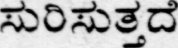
ಸುರಿಸುತ್ತದೆ
